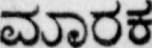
ಮಾರಕ
